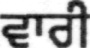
ਵਾਰੀ
